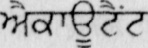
ਐਕਾਊਟੈਂਟ
